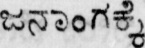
ಜನಾಂಗಕ್ಕೆ
